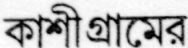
কাশীগ্রামের
